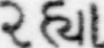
રહ્યા
